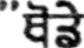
''ਥੋੜੇ
